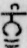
ਨੂੰ
